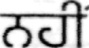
ਨਹੀਂ
